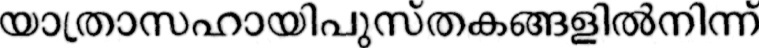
യാത്രാസഹായിപുസ്‌തകങ്ങളില്‍നിന്ന്
